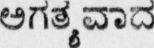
ಅಗತ್ಯವಾದ
